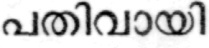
പതിവായി
